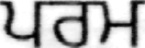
ਪਰਮ
